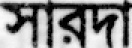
সারদা
